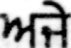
ਅਜੇ
